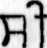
ਸੀ
